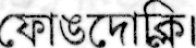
ফোঙদোক্লি।
